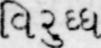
વિરુધ્ધ
